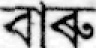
বাৰু
